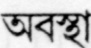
অবস্থা
